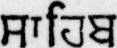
ਸਾਹਿਬ
